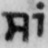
ਸਾਂ
